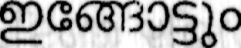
ഇങ്ങോട്ടും
